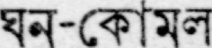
ঘন-কোমল
